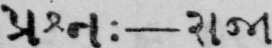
પ્રશ્નઃ-રાજા
